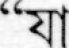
"যা
